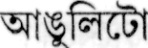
আঙুলিটো
